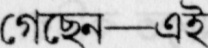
গেছেন-এই
